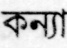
কন্যা
